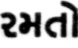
રમતો
